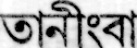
তানীংবা
